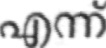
എന്ന്
